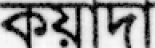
কয়াদা
